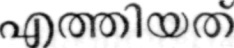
എത്തിയത്
